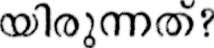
യിരുന്നത്?
